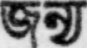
জন্য
